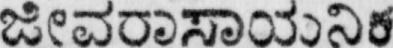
ಜೀವರಾಸಾಯನಿಕ
